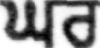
ਘਰ
